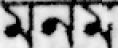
মনম
